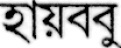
হায়ববু
